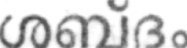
ശബ്ദം
